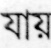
যায়
